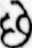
છે
